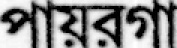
পায়রগা
